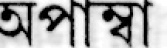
অপাম্বা
